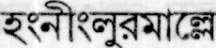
হংনীংলুরমাল্লে
